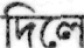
দিলে
